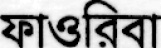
ফাওরিবা
